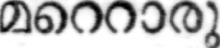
മറ്റൊരു
